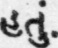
હતું.
